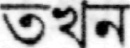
তখন
